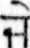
ਜੇ
